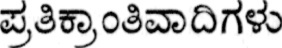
ಪ್ರತಿಕ್ರಾಂತಿವಾದಿಗಳು
